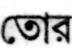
তোর
